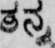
ತನ್ನ
